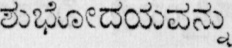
ಶುಭೋದಯವನ್ನು
